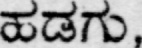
ಹಡಗು,
